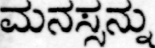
ಮನಸ್ಸನ್ನು
